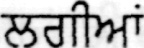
ਲਗੀਆਂ
